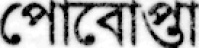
পোবোপ্তা
